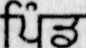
ਪਿੰਡ
